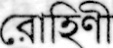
রোহিণী
